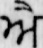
ਐ
